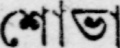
শোভা
